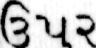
ઉપર
